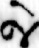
જે
